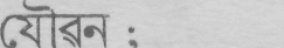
যৌৱন;
